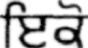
ਇਕੋ
